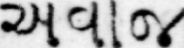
અવાજ
